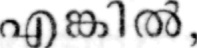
എങ്കില്‍,
